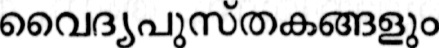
വൈദ്യപുസ്തകങ്ങളും
